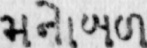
મનોબળ
